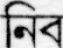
নিব
